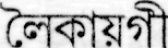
লৈকায়গী
